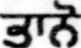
ਭਾਨੋ
